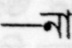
–না
